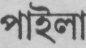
পাইলা
